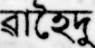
ৱাহৈদু
